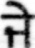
ਜੇ
